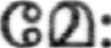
മേ:
